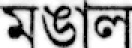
মঙাল
